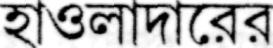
হাওলাদারের
